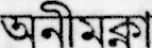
অনীমক্না
